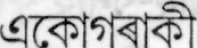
একোগৰাকী
